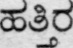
ಹತ್ತಿರ
